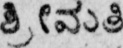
ಶ್ರೀಮತಿ
